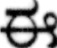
ಈ
